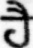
ਹੈ
